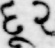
દૂર
